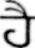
ਹੈ
